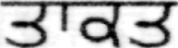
ਤਾਕਤ
